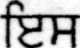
ਇਸ
